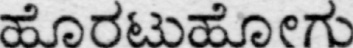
ಹೊರಟುಹೋಗು
